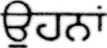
ਉਹਨਾਂ
